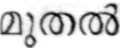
മുതല്‍
